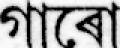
গাৰো
